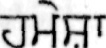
ਹਮੇਸ਼ਾਂ
